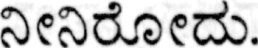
ನೀನಿರೋದು.
